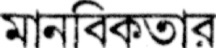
মানবিকতার
